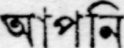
আপনি
